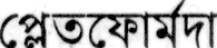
প্লেতফোর্মদা
